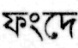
ফংদে
